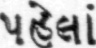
પહેલાં
